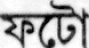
ফটো
